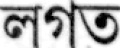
লগত
